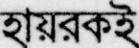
হায়রকই
